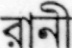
রানী
